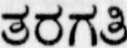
ತರಗತಿ
